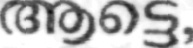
ആട്ടെ,
